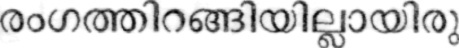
രംഗത്തിറങ്ങിയില്ലായിരു
